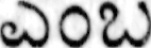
ಎಂಬ
